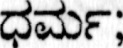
ಧರ್ಮ;
